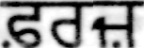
ਫ਼ਰਜ਼
